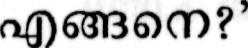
എങ്ങനെ?’
